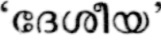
'ദേശീയ'
